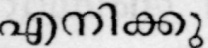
എനിക്കു
